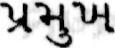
પ્રમુખ
